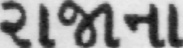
રાજાના
